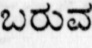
ಬರುವ
